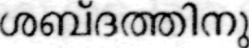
ശബ്ദത്തിനു
